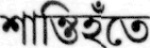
শান্তিহঁতে
